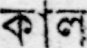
কাল
